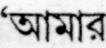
‘আমার
